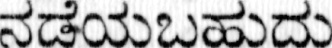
ನಡೆಯಬಹುದು
